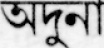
অদুনা
